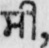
ਸੀ,
